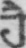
ਹੈ
